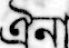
ঐনা
